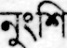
নুংশি
